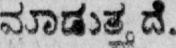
ಮಾಡುತ್ತದೆ.
